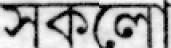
সকলো
